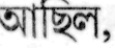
আছিল,
